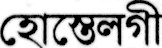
হোস্তেলগী
